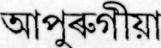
আপুৰুগীয়া
